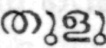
തുളു
